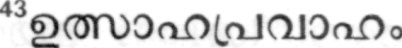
43ഉത്സാഹപ്രവാഹം
